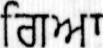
ਗਿਆ
